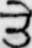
ਤੇ
